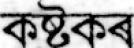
কষ্টকৰ
